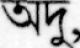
অদু,
